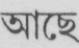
আছে
